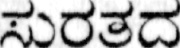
ಸುರತದ
